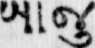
બાજુ
